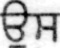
ਉਸ
